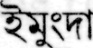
ইমুংদা
